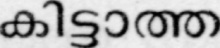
കിട്ടാത്ത
